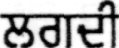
ਲਗਦੀ
